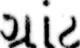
ગ્રાંટ
